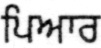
ਪਿਆਰ
